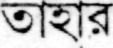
তাহার
